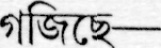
গজিছে-
